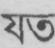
যত
